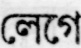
লেগে
